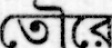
তৌরে
